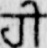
ਹੀ
